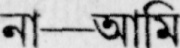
না-আমি
